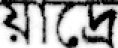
য়াদ্রে
